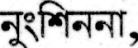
নুংশিননা,
